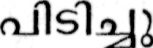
പിടിച്ചു
